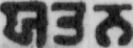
ਯਤਨ
